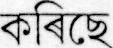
কৰিছে
